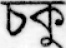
চকু
